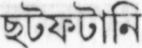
ছটফটানি
